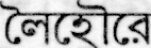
লৈহৌরে
